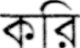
করি
